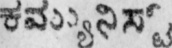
ಕಮ್ಯುನಿಸ್ಟ್
